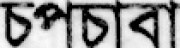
চপচাবা
